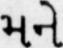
મને
